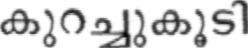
കുറച്ചുകൂടി
